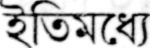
ইতিমধ্যে
